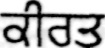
ਕੀਰਤ
